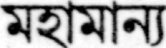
মহামান্য
